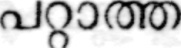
പറ്റാത്ത
